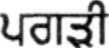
ਪਗੜੀ
